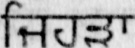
ਜਿਹੜਾ
